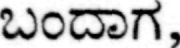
ಬಂದಾಗ,
